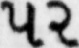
પર
